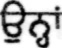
ਉਨ੍ਹਾਂ
